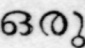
ഒരു
